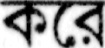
করে
